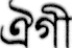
ঐগী
